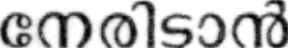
നേരിടാന്‍
